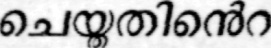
ചെയ്തതിന്റെ
